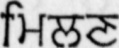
ਮਿਲਣ
